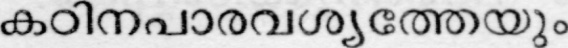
കഠിനപാരവശ്യത്തേയും
